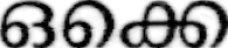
ഒക്കെ
